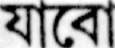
যাবো
